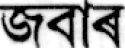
জবাৰ
